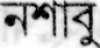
নশাবু
